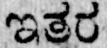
ಇತರ
